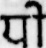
ਧੀ
